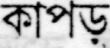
কাপড়
